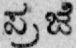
ಪ್ರಜೆ
